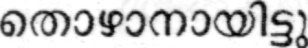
തൊഴാനായിട്ടു
